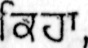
ਕਿਹਾ,
